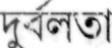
দুর্বলতা
